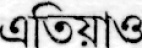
এতিয়াও
